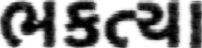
ભક્ત્યા
